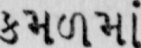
કમળમાં
